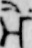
ਮੈਂ
